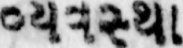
વ્યવસ્થા
